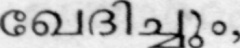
ഖേദിച്ചും,
